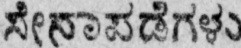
ಸೇನಾಪಡೆಗಳು
